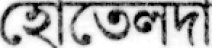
হোতেলদা
